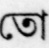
তো
